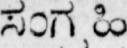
ಸಂಗ್ರಹಿ
